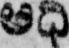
ಅಧಿ
